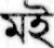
মই
